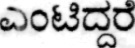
ಎಂಟಿದ್ದರೆ
